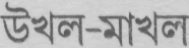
উখল-মাখল
